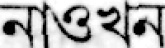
নাওখন
